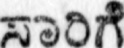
ಸಾರಿಗೆ
